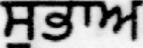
ਸੁਭਾਅ
